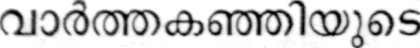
വാര്‍ത്തകഞ്ഞിയുടെ
